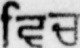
ਵਿਚ
